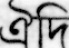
ঐদি
